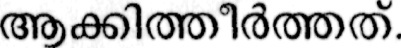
ആക്കിത്തീര്‍ത്തത്.
